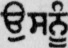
ਉਸਨੂੰ
